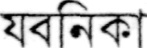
যবনিকা
